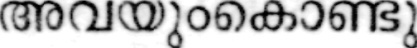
അവയുംകൊണ്ടു
